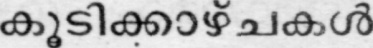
കൂടിക്കാഴ്ചകള്‍
